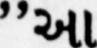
"આ
